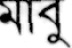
মাবু
